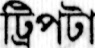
ট্রিপটা
